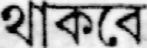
থাকবে
